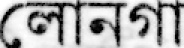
লোনগা
